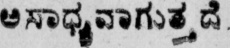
ಅಸಾಧ್ಯವಾಗುತ್ತದೆ.
